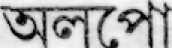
অলপো
